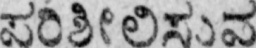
ಪರಿಶೀಲಿಸುವ
